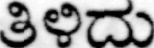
ತಿಳಿದು
